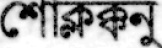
শোক্লক্কনু
